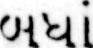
બધાં
